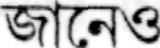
জানেও
